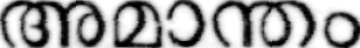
അമാന്തം
